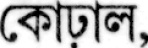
কোঢ়াল,
